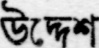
উদ্দেশ
